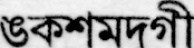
ঙকশমদগী
